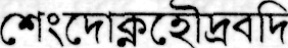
শেংদোক্নহৌদ্রবদি
